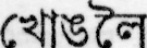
খোঙলৈ
